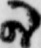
જે
